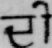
ਦੀ
